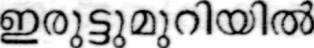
ഇരുട്ടുമുറിയില്‍
